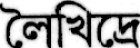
লৈখিদ্রে
